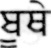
ਬੂਥੇ
